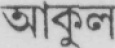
আকুল
